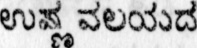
ಉಷ್ಣವಲಯದ
